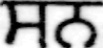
ਸਨ
